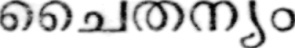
ചൈതന്യം
